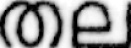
തല
